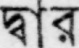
দ্বার
